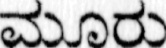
ಮೂರು
